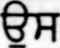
ਉਸ
